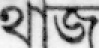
থাজ
